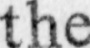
the
